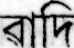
ৱাদি
